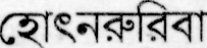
হোৎনরুরিবা
